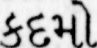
કદમો
